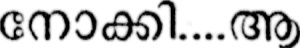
നോക്കി....ആ
